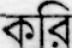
করি
